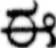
ಈ
